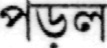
পড়ল
